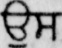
ਉਸ
